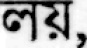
লয়,
